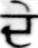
ਦੇ
